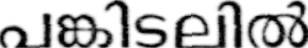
പങ്കിടലില്‍
